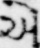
એ
